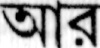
আর
